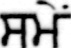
ਸਮੇਂ
